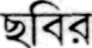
ছবির
